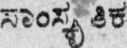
ಸಾಂಸ್ಕೃತಿಕ
